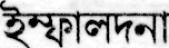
ইম্ফালদনা
